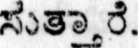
ಸುತ್ತಾರೆ.
